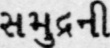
સમુદ્રની
